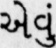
એવું
